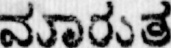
ಮಾರುತ
